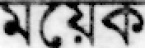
ময়েক
